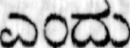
ಎಂದು
